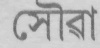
সৌৱা
